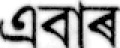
এবাৰ
